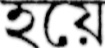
হয়ে
